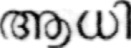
ആധി
